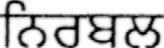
ਨਿਰਬਲ
